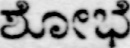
ಶೋಭೆ
